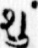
શું
